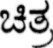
ಚಿತ್ರ
